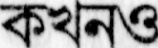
কখনও
